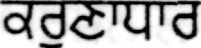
ਕਰੁਣਾਧਾਰ
